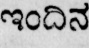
ಇಂದಿನ
